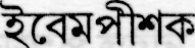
ইবেমপীশক
